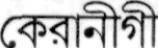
কেরানীগী
